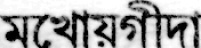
মখোয়গীদা
